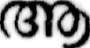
ആ
